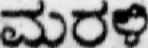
ಮರಳಿ
